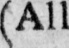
(All
